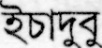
ইচাদুবু
